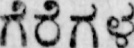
ಗೆರೆಗಳ
